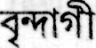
বৃন্দাগী
